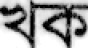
খক
